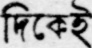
দিকেই
